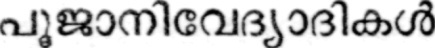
പൂജാനിവേദ്യാദികള്‍
